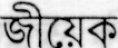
জীয়েক
